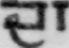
ਦਾ
